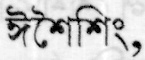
ঈশৈশিং,
